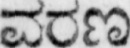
ವರಣ
